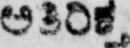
ಅತಿರಿಕ್ತ
